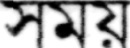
সময়
